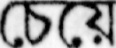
চেয়ে
